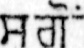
ਸਗੋਂ
